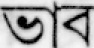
ভাব
